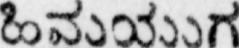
ಹಿಮಯುಗ
